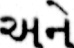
અને
